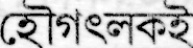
হৌগৎলকই
